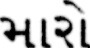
મારો
